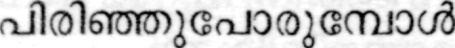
പിരിഞ്ഞുപോരുമ്പോള്‍
